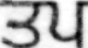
ਤਪ
